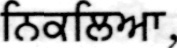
ਨਿਕਲਿਆ,
